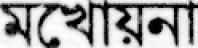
মখোয়না
